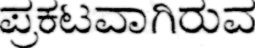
ಪ್ರಕಟವಾಗಿರುವ
